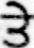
ਤੇ
